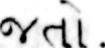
જતો.
